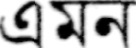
এমন
